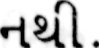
નથી.
